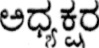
ಅಧ್ಯಕ್ಷರ
